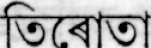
তিৰোতা
